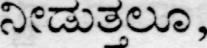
ನೀಡುತ್ತಲೂ,
